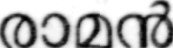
രാമന്‍
